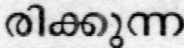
രിക്കുന്ന
